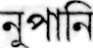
নুপানি
